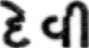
દેવી
